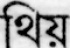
থিয়
